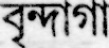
বৃন্দাগা
